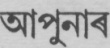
আপুনাৰ
